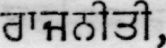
ਰਾਜਨੀਤੀ,
